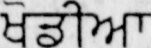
ਖੋਡੀਆ
